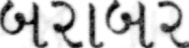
બરાબર
